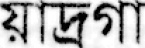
য়াদ্রগা
